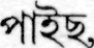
পাইছ,
